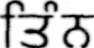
ਤਿੰਨ
